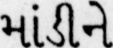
માંડીને
